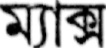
ম্যাক্স
